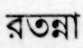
রতন্না
